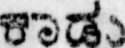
ಕಾಡು
